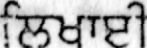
ਲਿਖਾਈ
